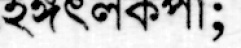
হেঙ্গৎলকপা;
